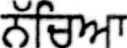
ਨੱਚਿਆ
